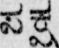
ಪಕ್ಷ
